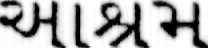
આશ્રમ
